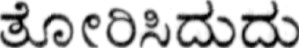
ತೋರಿಸಿದುದು
